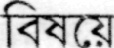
বিষয়ে
